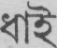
ধাই
